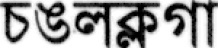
চঙলক্লগা
